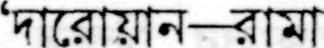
‘দারোয়ান—রামা
